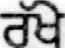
ਰੱਖੇ
